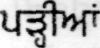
ਪੜ੍ਹੀਆਂ
